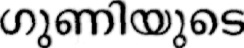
ഗുണിയുടെ
